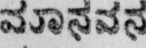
ಮಾನವನ
